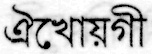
ঐখোয়গী
